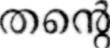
തന്റെ
